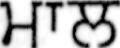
ਮਾਲ
